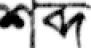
শব্দ
